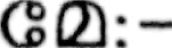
മേ:-
